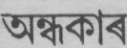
অন্ধকাৰ
